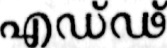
എഡ്ഢ്
